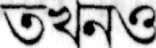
তখনও
